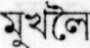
মুখলৈ
